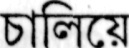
চালিয়ে
